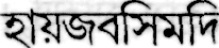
হায়জবসিমদি
